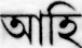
আহি
